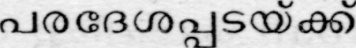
പരദേശപ്പടയ്ക്ക്
